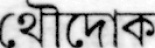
থৌদোক
